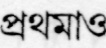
প্রথমাও
